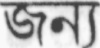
জন্য
